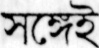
সঙ্গেই
